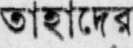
তাহাদের
